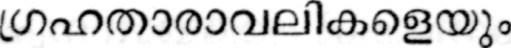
ഗ്രഹതാരാവലികളെയും
